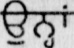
ਉਨ੍ਹਾਂ
